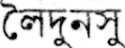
লৈদুনসু
